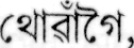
থোৱাঁগৈ,
